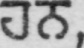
ਹਨ,
